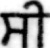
ਸੀ
